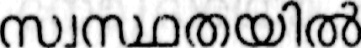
സ്വസ്ഥതയില്‍
